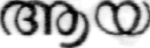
ആയ
